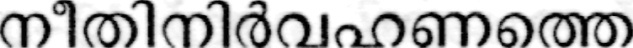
നീതിനിര്‍വഹണത്തെ
